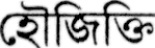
হৌজিক্তি
